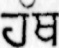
ਹੱਥ
